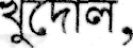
খুদোল,
